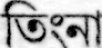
তিংনা
